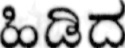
ಹಿಡಿದ
